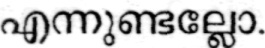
എന്നുണ്ടല്ലോ.
